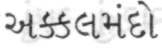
અક્કલમંદો
